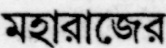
মহারাজের
